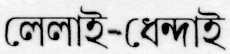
লেলাই-ধেন্দাই
